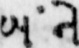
બંને
